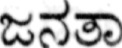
ಜನತಾ
